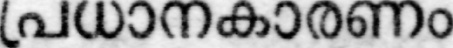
പ്രധാനകാരണം
